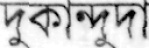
দুকান্দুদা
